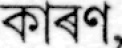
কাৰণ,
